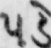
પડે
